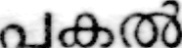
പകല്‍
